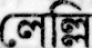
লেল্লি
